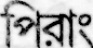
পিরাং
